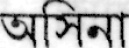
অসিনা
